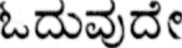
ಓದುವುದೇ
